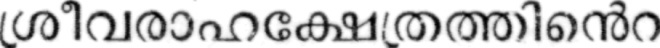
ശ്രീവരാഹക്ഷേത്രത്തിന്റെ
